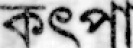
কৎপা
